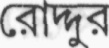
রোদ্দুর
